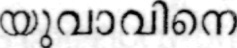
യുവാവിനെ
